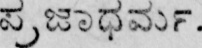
ಪ್ರಜಾಧರ್ಮ.
